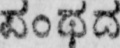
ಪಂಥದ
